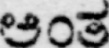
ಅಂತ
